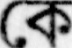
কে
